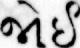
જોઇ
